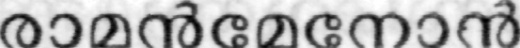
രാമന്‍മേനോന്‍
